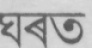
ঘৰত
